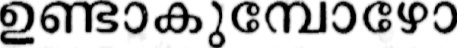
ഉണ്ടാകുമ്പോഴോ
